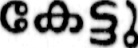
കേട്ടു
